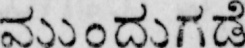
ಮುಂದುಗಡೆ
